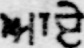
ਆਏ
